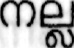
നല്ല
